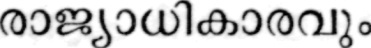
രാജ്യാധികാരവും
